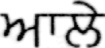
ਆਲੇ
